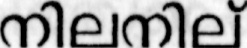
നിലനില്
